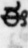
ಈ
